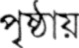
পৃষ্ঠায়
